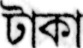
টাকা
